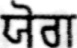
ਯੋਗ
